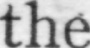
the
